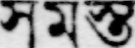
সমস্ত
